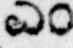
ಎಂ
